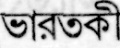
ভারতকী
